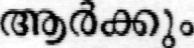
ആര്‍ക്കും
